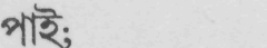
পাই;
